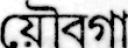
য়ৌবগা
